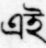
এই
